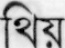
থিয়
